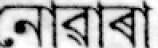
নোৱাৰা
